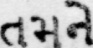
તમને
